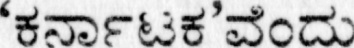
‘ಕರ್ನಾಟಕ’ವೆಂದು
